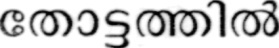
തോട്ടത്തില്‍
